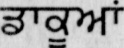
ਡਾਕੂਆਂ
